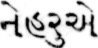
નેહરુએ
